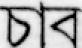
চাব
